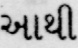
આથી
